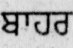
ਬਾਹਰ
